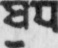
ਬੁਧ
